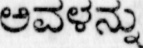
ಅವಳನ್ನು
